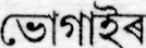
ভোগাইৰ
